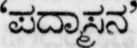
‘ಪದ್ಮಾಸನ’
